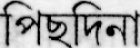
পিছদিনা
